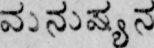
ಮನುಷ್ಯನ
